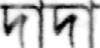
দাদা
